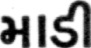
માડી
